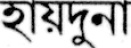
হায়দুনা
